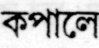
কপালে
